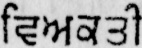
ਵਿਅਕਤੀ
